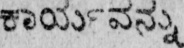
ಕಾರ್ಯವನ್ನು
